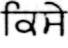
ਕਿਸੇ
